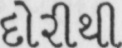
દોરીથી
